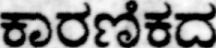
ಕಾರಣಿಕದ
